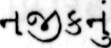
નજીકનું
